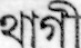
থাগী
